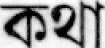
কথা
